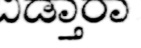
ಬಿಡ್ತಾರಾ
